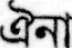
ঐনা
